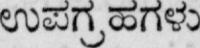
ಉಪಗ್ರಹಗಳು
